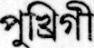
পুখ্রিগী
